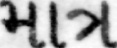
માત્ર
